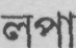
লপা
